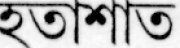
হতাশাত
